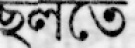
ছলতে
